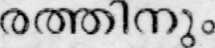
രത്തിനും
